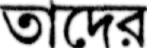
তাদের
